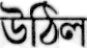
উঠিল
